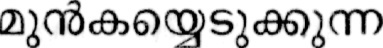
മുന്‍കയ്യെടുക്കുന്ന
